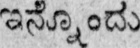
ಇನ್ನೊಂದು
